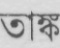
তাঙ্ক
